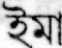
ইমা
